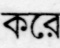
করে
